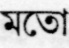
মতো
